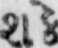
શકે
